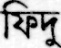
ফিদু
